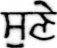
ਸੁਣੇ
